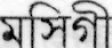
মসিগী
